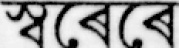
স্বৰেৰে
